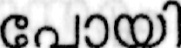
പോയി
